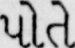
પોતે
